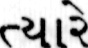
ત્યારે
